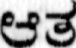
ಆತ
